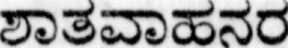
ಶಾತವಾಹನರ
